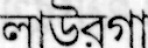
লাউরগা
